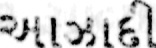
આઝાદી
